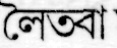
লৈতবা
